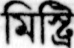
মিস্ট্রি
